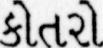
કોતરો
